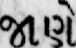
જાણે
